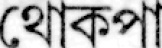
থোকপা
